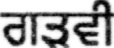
ਗੜਵੀ
